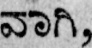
ವಾಗಿ,
